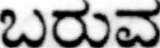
ಬರುವ
